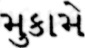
મુકામે
